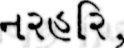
નરહરિ,
